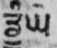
ਡੂੰਘੇ
